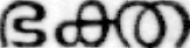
ഭക്ത
